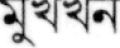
মুখখন
